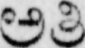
ಅತಿ
